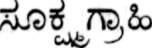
ಸೂಕ್ಷ್ಮಗ್ರಾಹಿ
